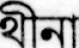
থীনা
